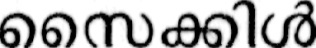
സൈക്കിള്‍
